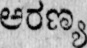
ಅರಣ್ಯ
